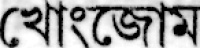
খোংজোম
